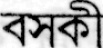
বসকী
